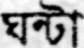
ঘন্টা
